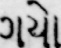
ગયો
